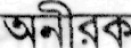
অনীরক
